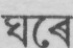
ঘৰে
